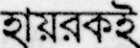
হায়রকই
